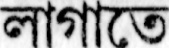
লাগাতে
